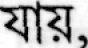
যায়,
